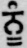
ਨੂੰ
